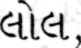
લોલ,
